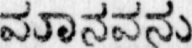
ಮಾನವನು
